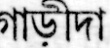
গাড়ীদা
